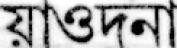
য়াওদনা
